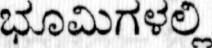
ಭೂಮಿಗಳಲ್ಲಿ
